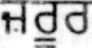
ਜ਼ਰੂਰ
